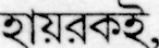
হায়রকই,
